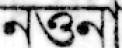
নত্তনা
